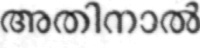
അതിനാല്‍
